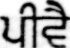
ਪੀਵੈ
